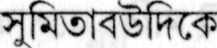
সুমিতাবউদিকে
